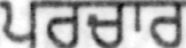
ਪਰਚਾਰ
